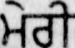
ਮੇਰੀ
